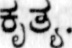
ಕೃತ್ಯ.
